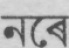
নৰে
